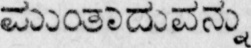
ಮುಂತಾದುವನ್ನು
